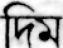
দিম
